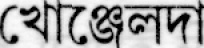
খোঞ্জেলদা
